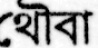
থৌবা
